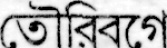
তৌরিবগে
